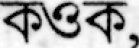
কওক,
